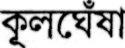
কূলঘেঁষা
